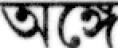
অঙ্গে
